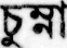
চুম্না
